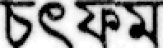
চৎফম
